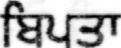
ਬਿਪਤਾ
